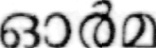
ഓര്‍മ
